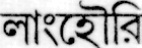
লাংহৌরি
